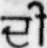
ਦੀ
